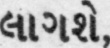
લાગશે,
